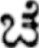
ಚೆ
